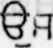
ਉਸ
